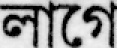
লাগে
